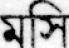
মসি
